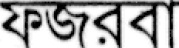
ফজরবা
